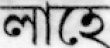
লাহে
